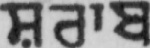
ਸ਼ਰਾਬ
